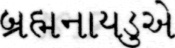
બ્રહ્મનાયડુએ
